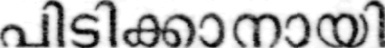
പിടിക്കാനായി
